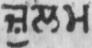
ਜ਼ੁਲਮ
